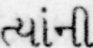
ત્યાંની
